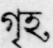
গৃহ,
